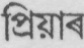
প্ৰিয়াৰ
